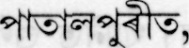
পাতালপুৰীত,
